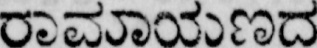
ರಾಮಾಯಣದ
